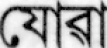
যোৱা
